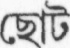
ছোট
